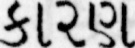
કારણ
